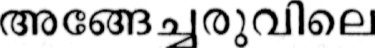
അങ്ങേച്ചരുവിലെ
